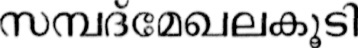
സമ്പദ്മേഖലകൂടി
